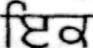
ਇਕ
